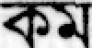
কম
